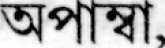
অপাম্বা,
